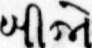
બીજો
